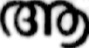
ആ
